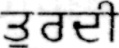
ਤੁਰਦੀ
